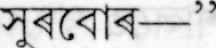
সুৰবোৰ-"
